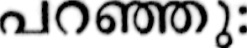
പറഞ്ഞു:
